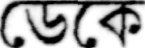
ডেকে
